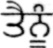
ਤੈਨੂੰ
